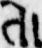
તો
